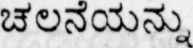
ಚಲನೆಯನ್ನು
